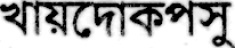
খায়দোকপসু
